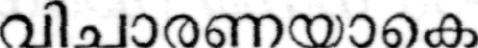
വിചാരണയാകെ
